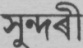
সুন্দৰী
